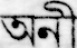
অনী
